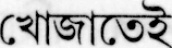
খোজাতেই
